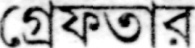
গ্রেফতার
